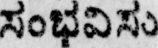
ಸಂಭವಿಸು
